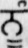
ਨੂੰ
